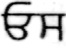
ਓਸ
